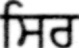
ਸਿਰ
